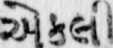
એકલી
